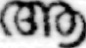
ആ
